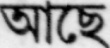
আছে
